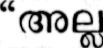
“അല്ല
